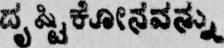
ದೃಷ್ಟಿಕೋನವನ್ನು
